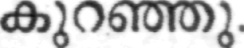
കുറഞ്ഞു.
